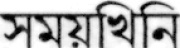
সময়খিনি
